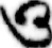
ও
